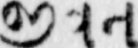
જીવન
